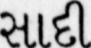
સાદી
